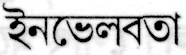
ইনভেলবতা
